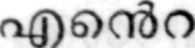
എന്റെ
